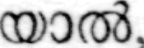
യാല്‍,
